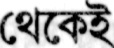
থেকেই
